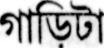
গাড়িটা
